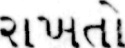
રાખતો
